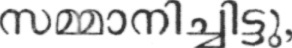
സമ്മാനിച്ചിട്ടു,
